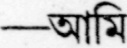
–আমি
